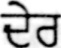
ਦੇਰ
